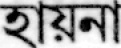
হায়না
